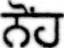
ਨੋਂਹ
